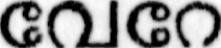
വേറേ
